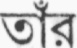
তাঁর
